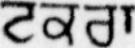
ਟਕਰਾ
